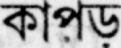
কাপড়
